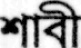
শাবী
